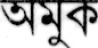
অমুক
